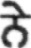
ਨੇ
